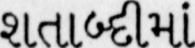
શતાબ્દીમાં
